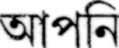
আপনি
